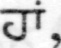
ਹਾਂ,
